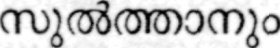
സുല്‍ത്താനും
